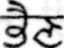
ਭੈਣ
